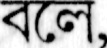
বলে,
